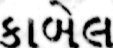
કાબેલ
